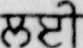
ਲਈ
